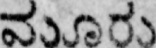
ಮೂರು
